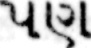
પણ
